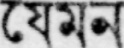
যেমন
